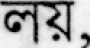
লয়,
